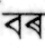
বৰ
